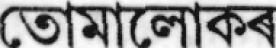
তোমালোকৰ
